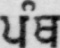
ਪੰਥ
